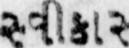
સ્વીકાર
